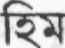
হিম
